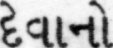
દેવાનો
